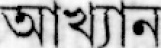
আখ্যান
